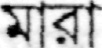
মারা
